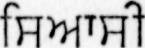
ਸਿਆਸੀ
